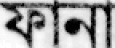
ফানা
